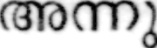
അന്നു
